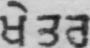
ਖੇਤਰ
